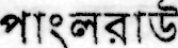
পাংলরাউ
